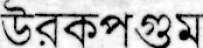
উরকপগুম
